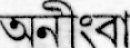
অনীংবা
